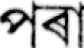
পৰা
